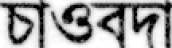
চাওবদা
